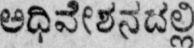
ಅಧಿವೇಶನದಲ್ಲಿ
